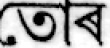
তোৰ
